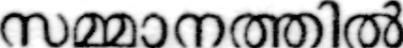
സമ്മാനത്തില്‍
